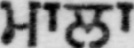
ਮਾਲਾ
